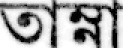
তাম্না
